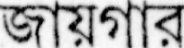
জায়গার
